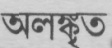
অলঙ্কৃত
